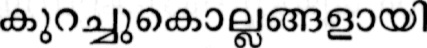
കുറച്ചുകൊല്ലങ്ങളായി
